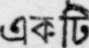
একটি
